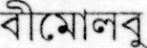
বীমোলবু
